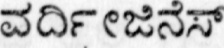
ವರ್ದೀಜಿನೆಸ್
